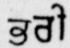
ਭਰੀ
